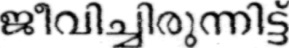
ജീവിച്ചിരുന്നിട്ട്
